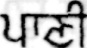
ਪਾਣੀ
